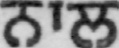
ਨਾਲ
